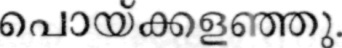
പൊയ്ക്കളഞ്ഞു.
